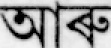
আৰু
